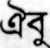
ঐবু
